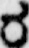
ರ
